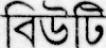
বিউটি
